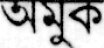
অমুক
